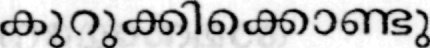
കുറുക്കിക്കൊണ്ടു
